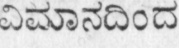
ವಿಮಾನದಿಂದ
